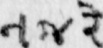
નજરે
